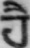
ਹੈ
